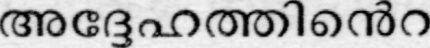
അദ്ദേഹത്തിന്റെ
